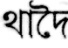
থাদৈ
